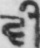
ਵੀ
